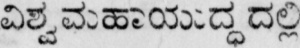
ವಿಶ್ವಮಹಾಯುದ್ಧದಲ್ಲಿ
